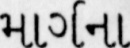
માર્ગના
